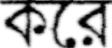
করে
